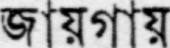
জায়গায়
